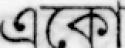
একো
